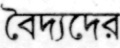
বৈদ্যদের
